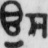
ਉਸ
